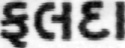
ફલદા
